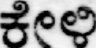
ಕೇಳಿ
